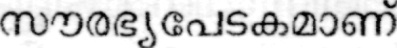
സൌരഭ്യപേടകമാണ്
